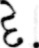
દે.
